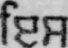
ਇਸ
